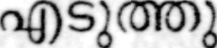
എടുത്തു
